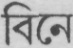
বিনে
